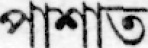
পাশাত
